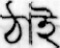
ঠাই
